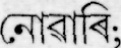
নোৱাৰি;
